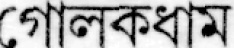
গোলকধাম
